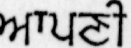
ਆਪਣੀ
